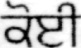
ਕੋਈ
